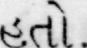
હતો.
